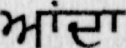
ਆਂਦਾ
